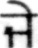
ਜੇ
